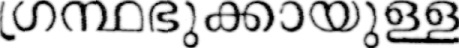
ഗ്രന്ഥഭുക്കായുള്ള
